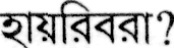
হায়রিবরা?
